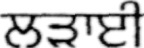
ਲੜਾਈ
